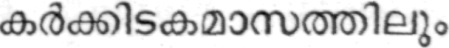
കര്‍ക്കിടകമാസത്തിലും
